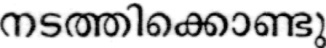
നടത്തിക്കൊണ്ടു
